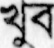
খুব
